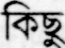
কিছু
